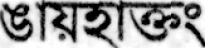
ঙায়হাক্তং
